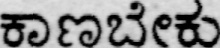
ಕಾಣಬೇಕು
